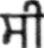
ਸੀ
